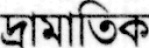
দ্রামাতিক
